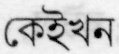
কেইখন
